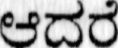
ಆದರೆ
